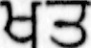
ਖਤ
